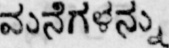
ಮನೆಗಳನ್ನು
